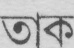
তাক
